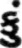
કું
